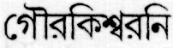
গৌরকিশ্বরনি
